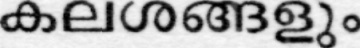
കലശങ്ങളും
